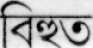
বিহুত
